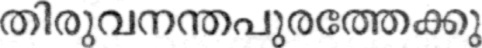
തിരുവനന്തപുരത്തേക്കു
